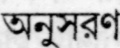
অনুসরণ
